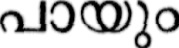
പായും
